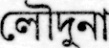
লৌদুনা
